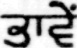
ਭਾਵੇਂ
